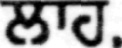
ਲਾਹ,
